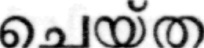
ചെയ്ത
